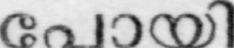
പോയി
